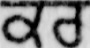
ਕਰ
